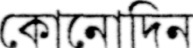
কোনোদিন
